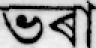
ভৰা
